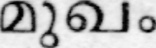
മുഖം
